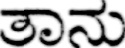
ತಾನು
